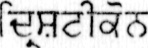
ਦ੍ਰਿਸ਼ਟੀਕੋਨ
